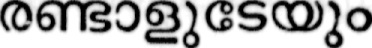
രണ്ടാളുടേയും
